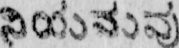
ನಿಯಮವು
